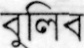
বুলিব
